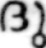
ദു
